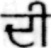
ਦੀ
